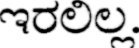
ಇರಲಿಲ್ಲ.
